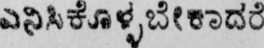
ಎನಿಸಿಕೊಳ್ಳಬೇಕಾದರೆ
